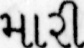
મારી
